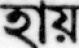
হায়
